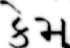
કેમ
